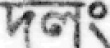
দলং
